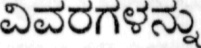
ವಿವರಗಳನ್ನು
